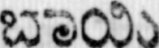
ಬಾಯಿ
